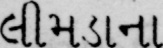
લીમડાના
